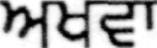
ਅਖਵਾ
